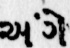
અંગે
